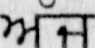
ਅੱਜ
